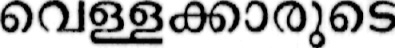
വെള്ളക്കാരുടെ
